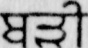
ਬੜੀ
